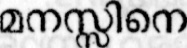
മനസ്സിനെ
